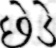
છેડે
